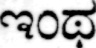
ಇಂಥ
